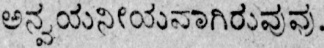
ಅನ್ವಯನೀಯವಾಗಿರುವುವು.
